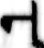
ન
